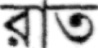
রাত
